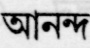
আনন্দ
